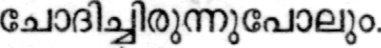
ചോദിച്ചിരുന്നുപോലും.
